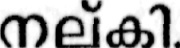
നല്കി.
